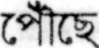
পৌঁছে
